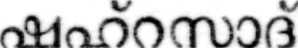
ഷഹ്റസാദ്
